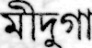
মীদুগা
